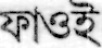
ফাওই
